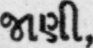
જાણી,
